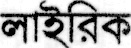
লাইরিক
